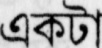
একটা
